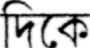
দিকে
